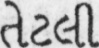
તેટલી
